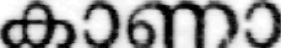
കാണാ
